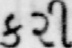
કરી
